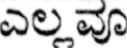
ಎಲ್ಲವೂ
